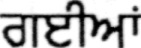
ਗਈਆਂ
